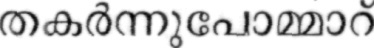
തകര്‍ന്നുപോമ്മാറ്
